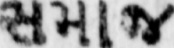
સમાજ
